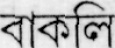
বাকলি
